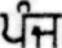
ਪੰਜ
